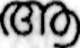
ആ
